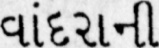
વાંદરાની
